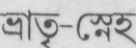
ভ্ৰাতৃ-স্নেহ
